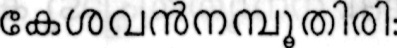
കേശവന്‍നമ്പൂതിരി:
